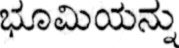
ಭೂಮಿಯನ್ನು
